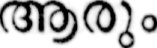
ആരും
